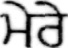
ਮੇਰੇ
